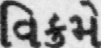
વિક્રમે
